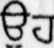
ਉਹ
